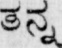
ತನ್ನ
